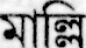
মাল্লি
